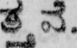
ತ್ತವೆ.
